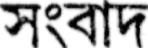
সংবাদ
